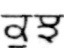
ਕੁਝ
